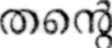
തന്റെ
